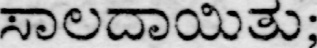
ಸಾಲದಾಯಿತು;
